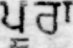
ਪੂਰਾ
